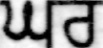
ਘਰ
